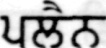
ਪਲੈਨ
